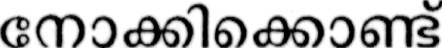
നോക്കിക്കൊണ്ട്
